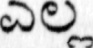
ಎಲ್ಲ
